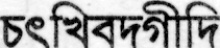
চৎখিবদগীদি
